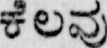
ಕೆಲವು
